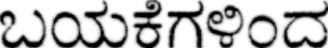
ಬಯಕೆಗಳಿಂದ
